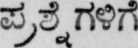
ಪ್ರಶ್ನೆಗಳಿಗೆ
